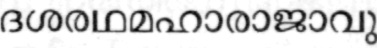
ദശരഥമഹാരാജാവു
